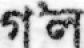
গ'ল
